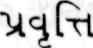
પ્રવૃત્તિ
